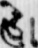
હો
